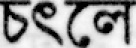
চৎলে
